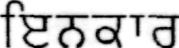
ਇਨਕਾਰ
